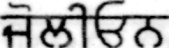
ਜੋਲੀਓਨ
